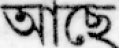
আছে
